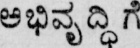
ಅಭಿವೃದ್ಧಿಗೆ
